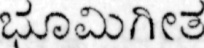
ಭೂಮಿಗೀತ
